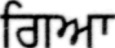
ਗਿਆ
